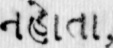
નહોતા,
